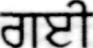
ਗਈ
